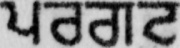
ਪਰਗਟ
